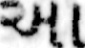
આ
